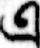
এ
